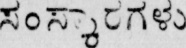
ಸಂಸ್ಕಾರಗಳು
